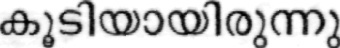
കൂടിയായിരുന്നു
